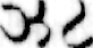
ઝટ
